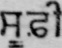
ਸੂਫ਼ੀ
